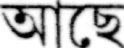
আছে
